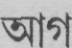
আগ
